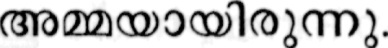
അമ്മയായിരുന്നു.
